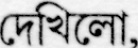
দেখিলো,
